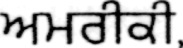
ਅਮਰੀਕੀ,
